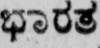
ಭಾರತ
